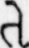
તે
